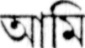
আমি
